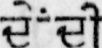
ਦੇਂਦੀ
